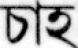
চাহ
